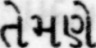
તેમણે
